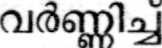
വര്‍ണ്ണിച്ച്
